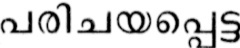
പരിചയപ്പെട്ട
